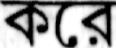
করে
